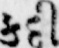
કદી
